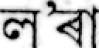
ল'ৰা
